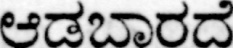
ಆಡಬಾರದೆ
